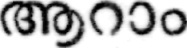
ആറാം
